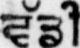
ਵੱਡੀ
